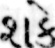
શકે
